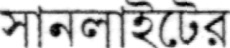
সানলাইটের
